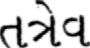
તત્રેવ
